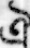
ঐ
